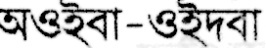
অওইবা-ওইদবা
